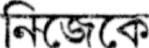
নিজেকে
